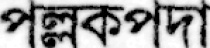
পল্লকপদা
